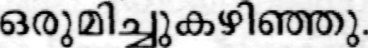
ഒരുമിച്ചുകഴിഞ്ഞു.
